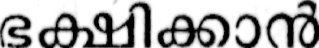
ഭക്ഷിക്കാന്‍
